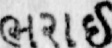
ભરાઈ
